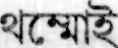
থম্মোই
